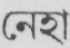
নেহা
